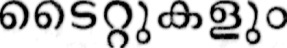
ടൈറ്റുകളും
